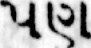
પણ
